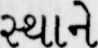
સ્થાને
